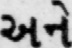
અને
